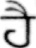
ਹੈ
